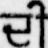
ਦੀ
